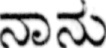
ನಾನು
